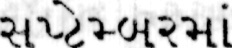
સપ્ટેમ્બરમાં
